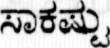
ಸಾಕಷ್ಟು
